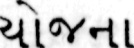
યોજના
